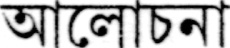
আলোচনা
